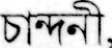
চান্দনী,
